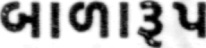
બાળારૂપ
